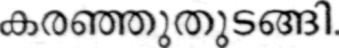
കരഞ്ഞുതുടങ്ങി.
